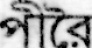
পীরৈ
